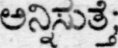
ಅನ್ನಿಸುತ್ತೆ:
